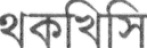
থকখিসি
